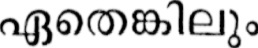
ഏതെങ്കിലും
